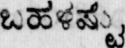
ಬಹಳಷ್ಟು
